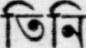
তিনি
